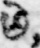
છે,
